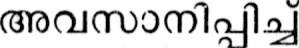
അവസാനിപ്പിച്ച്
